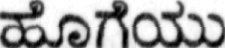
ಹೊಗೆಯು
